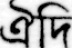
ঐদি
